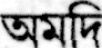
অমদি
